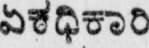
ಏಕಧಿಕಾರಿ
